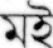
মই
